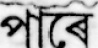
পাৰে
